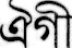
ঐগী
